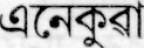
এনেকুৱা
